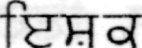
ਇਸ਼ਕ
